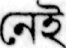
নেই
